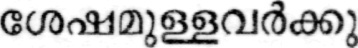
ശേഷമുള്ളവര്‍ക്കു
